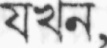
যখন,
